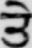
ਤੇ
